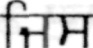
ਜਿਸ
